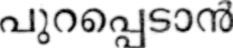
പുറപ്പെടാന്‍
